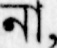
না,
